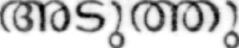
അടുത്തു
